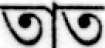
তাত
